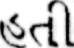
હતી
